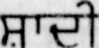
ਸ਼ਾਦੀ
